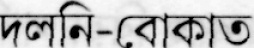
দলনি-বোকাত
